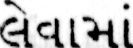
લેવામાં
